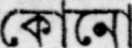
কোনো
